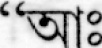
"আঃ
